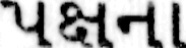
પક્ષના
